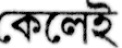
কেলেই
